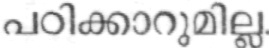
പഠിക്കാറുമില്ല.
